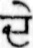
ਦੇ
